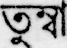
তুম্বা
